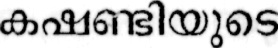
കഷണ്ടിയുടെ
